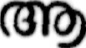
ആ
